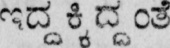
ಇದ್ದಕ್ಕಿದ್ದಂತೆ
